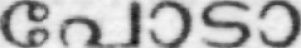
പോടാ
